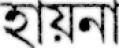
হায়না
